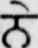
ਨੇ
